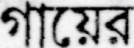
গায়ের
